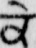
ਕੇ
